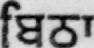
ਬਿਠਾ
